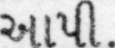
આપી.
